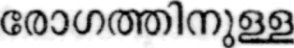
രോഗത്തിനുള്ള
